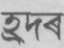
হ্ৰদৰ
